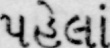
પહેલાં
